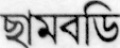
ছামবডি
